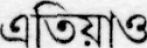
এতিয়াও
